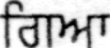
ਗਿਆ
